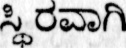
ಸ್ಥಿರವಾಗಿ
